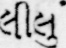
લીલું
